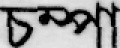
চম্পা
